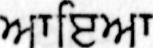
ਆਇਆ
